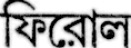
ফিরোল
